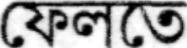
ফেলতে
